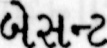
બેસન્ટ
